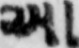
આ
